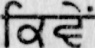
ਕਿਵੇਂ
